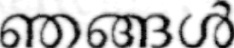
ഞങ്ങള്‍
